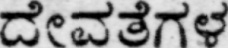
ದೇವತೆಗಳ
